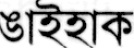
ঙাইহাক
